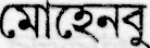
মোহেনবু
